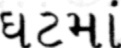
ઘટમાં
